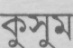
কুসুম
